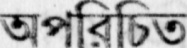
অপরিচিত
